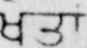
ਖਤਾ
